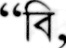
“বি,
